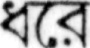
ধরে
